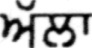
ਅੱਲਾ
